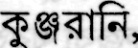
কুঞ্জরানি,
